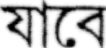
যাবে
